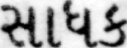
સાધક
